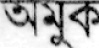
অমুক
